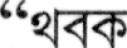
“থবক
